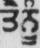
ਤੈਨੂੰ
